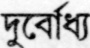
দুর্বোধ্য
